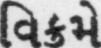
વિક્રમે
